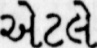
એટલે
